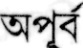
অপূর্ব
